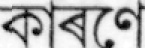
কাৰণে
